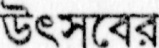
উত্সবের
